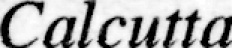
Calcutta
